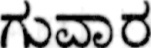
ಗುವಾರ
